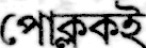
পোক্লকই
